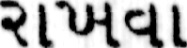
રાખવા
